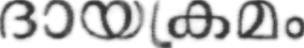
ദായക്രമം
